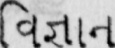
વિજ્ઞાન
